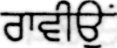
ਰਾਵੀਉਂ
